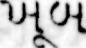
ખૂબ
